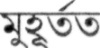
মুহূর্তত
